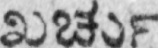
ಖರ್ಚು
